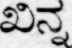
ಖಿನ್ನ
